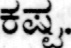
ಕಷ್ಟ.
